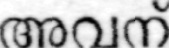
അവന്
